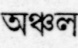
অঞ্চল
